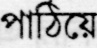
পাঠিয়ে
